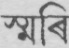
স্মৰি
